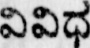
ವಿವಿಧ
